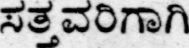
ಸತ್ತವರಿಗಾಗಿ
